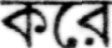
করে
